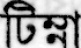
টিম্না
